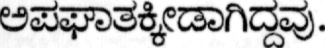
ಅಪಘಾತಕ್ಕೀಡಾಗಿದ್ದವು.
